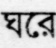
ঘরে
